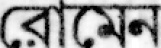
রোমেন
